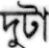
দুটা
